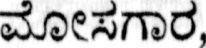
ಮೋಸಗಾರ,
